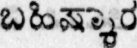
ಬಹಿಷ್ಕಾರ
